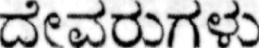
ದೇವರುಗಳು
